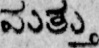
ಮತ್ತು
